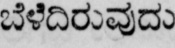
ಬೆಳೆದಿರುವುದು
